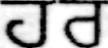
ਹਰ
